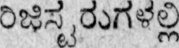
ರಿಜಿಸ್ಟರುಗಳಲ್ಲಿ
